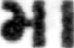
મા
